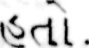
હતો.
